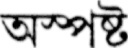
অস্পষ্ট
